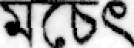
মচেৎ
